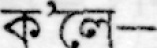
ক'লে-
